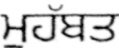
ਮੁਹੱਬਤ
